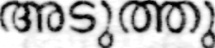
അടുത്തു
